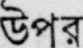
উপর
